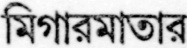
মিগারমাতার
